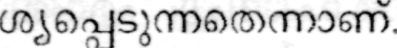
ശ്യപ്പെടുന്നതെന്നാണ്.
